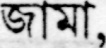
জামা,
